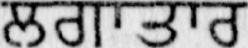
ਲਗਾਤਾਰ
